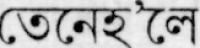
তেনেহ'লে
